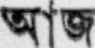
আজ
